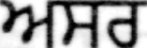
ਅਸਰ
